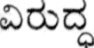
ವಿರುದ್ಧ
